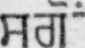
ਸਗੋਂ
